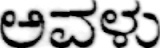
ಅವಳು
